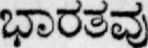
ಭಾರತವು
